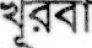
খূরবা
